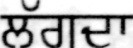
ਲੱਗਦਾ
